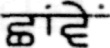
ਛਾਂਵੇਂ
